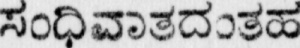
ಸಂಧಿವಾತದಂತಹ
